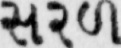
સરળ
